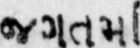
જગતમાં
